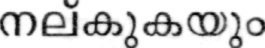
നല്കുകയും
